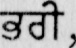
ਭਰੀ,
